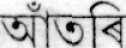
আঁতৰি
